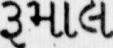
રૂમાલ
